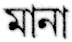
মানা
